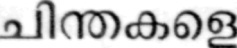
ചിന്തകളെ
